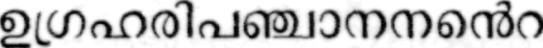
ഉഗ്രഹരിപഞ്ചാനനന്റെ
